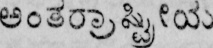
ಅಂತರ್ರಾಷ್ಟ್ರೀಯ
